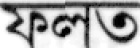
ফলত
